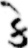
કે
